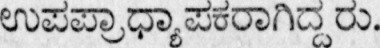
ಉಪಪ್ರಾಧ್ಯಾಪಕರಾಗಿದ್ದರು.
